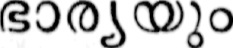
ഭാര്യയും
